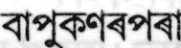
বাপুকণৰপৰা
